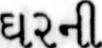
ઘરની
